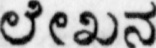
ಲೇಖನ
